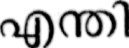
എന്തി
